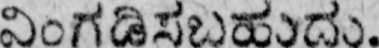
ವಿಂಗಡಿಸಬಹುದು.
